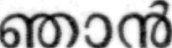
ഞാന്‍
